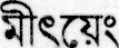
মীৎয়েং
